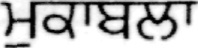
ਮੁਕਾਬਲਾ
